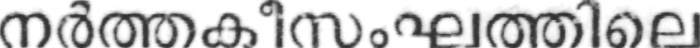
നര്‍ത്തകീസംഘത്തിലെ
